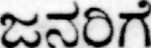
ಜನರಿಗೆ
